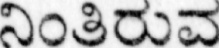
ನಿಂತಿರುವ
